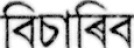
বিচাৰিব
